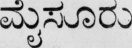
ಮೈಸೂರು
